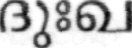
ദുഃഖ
